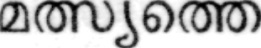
മത്സ്യത്തെ
